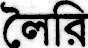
লৈরি
